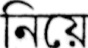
নিয়ে
